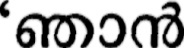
‘ഞാന്‍
